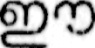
ഈ
